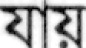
যায়
